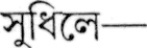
সুধিলে-
